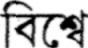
বিশ্বে
